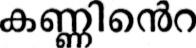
കണ്ണിന്റെ
